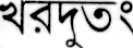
খরদুতং
